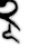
হূ
